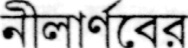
নীলার্ণবের
